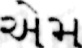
એમ
